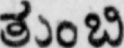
ತುಂಬಿ
